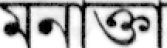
মনাক্তা
